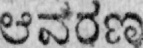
ಆವರಣ
